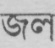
জল
